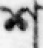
শ
